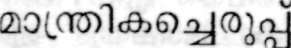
മാന്ത്രികച്ചെരുപ്പ്
